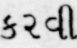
કરવી
